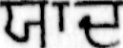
ਯਾਦ
